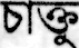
চাক্তু
